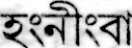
হংনীংবা
